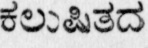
ಕಲುಷಿತದ
